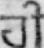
ਹੀ
